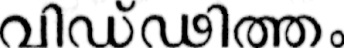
വിഡ്ഢിത്തം
